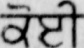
ਕੋਈ
